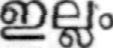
ഇല്ലം
